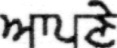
ਆਪਣੇ
